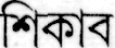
শিকাব
